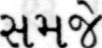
સમજે
